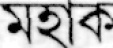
মহাক
